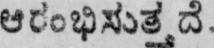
ಆರಂಭಿಸುತ್ತದೆ.
